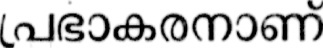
പ്രഭാകരനാണ്
